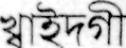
খ্বাইদগী
